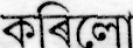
কৰিলো
